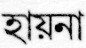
হায়না
